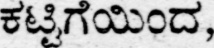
ಕಟ್ಟಿಗೆಯಿಂದ,
